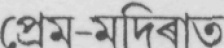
প্ৰেম-মদিৰাত
